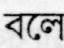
বলে
